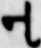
ન
